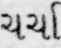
ચર્ચા
